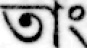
তাং
